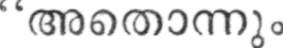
"അതൊന്നും
